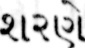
શરણે
